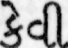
કેવી
